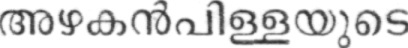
അഴകന്‍പിള്ളയുടെ
